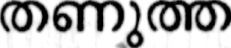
തണുത്ത
